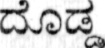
ದೊಡ್ಡ
